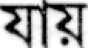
যায়
